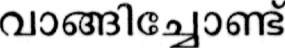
വാങ്ങിച്ചോണ്ട്
